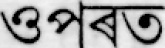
ওপৰত
